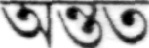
অন্তত
